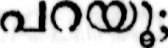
പറയൂ;
